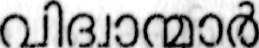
വിദ്വാന്മാര്‍
